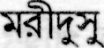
মরীদুসু
